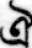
ঐ
